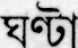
ঘণ্টা
